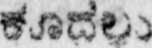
ಕೂದಲು
